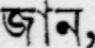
জান,
